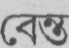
বেন্ত
